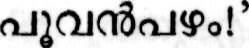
പൂവന്‍പഴം!'
